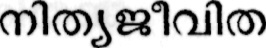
നിത്യജീവിത
